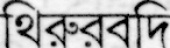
থিরুরবদি
